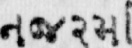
નજરમાં
